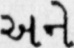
અને
